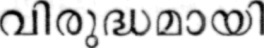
വിരുദ്ധമായി
